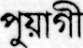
পুয়াগী
